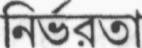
নির্ভরতা
